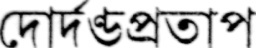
দোর্দণ্ডপ্রতাপ
